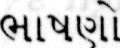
ભાષણો
